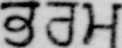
ਭਰਮ
